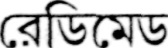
রেডিমেড
